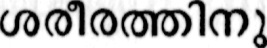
ശരീരത്തിനു
